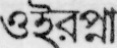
ওইরপ্না
